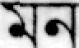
মন
